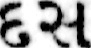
દસ
